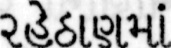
રહેઠાણમાં
